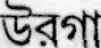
উরগা
